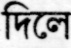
দিলে
